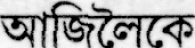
আজিলৈকে
